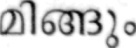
മിങ്ങും
